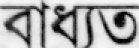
বাধ্যত
